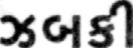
ઝબકી
